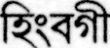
হিংবগী
